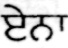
ਏਨਾ
